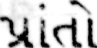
પ્રાંતો
